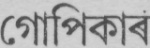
গোপিকাৰ
